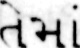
તેમાં
